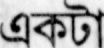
একটা
